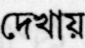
দেখায়
